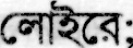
লোইরে;
